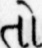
તો
